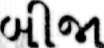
બીજા
